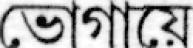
ভোগায়ে
